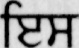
ਇਸ
